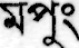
মপুং
